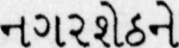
નગરશેઠને
